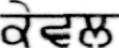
ਕੇਵਲ
